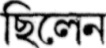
ছিলেন
